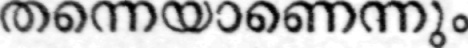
തന്നെയാണെന്നും
